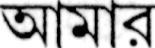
আমার
